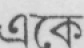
একে
